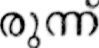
രുന്ന്
